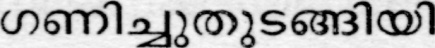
ഗണിച്ചുതുടങ്ങിയി
